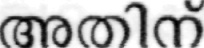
അതിന്
